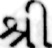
શ્રી
